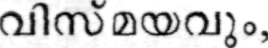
വിസ്മയവും,
